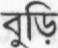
বুড়ি
